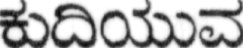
ಕುದಿಯುವ
